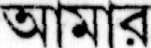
আমার
